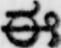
ಈ
